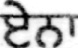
ਏਨਾ
